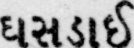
ઘસડાઈ
